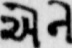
એને
